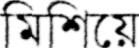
মিশিয়ে
